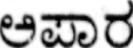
ಅಪಾರ
